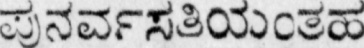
ಪುನರ್ವಸತಿಯಂತಹ
